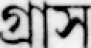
গ্রাস
